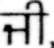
ਜੀ,
